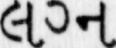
લગ્ન
